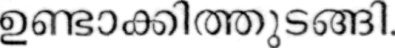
ഉണ്ടാക്കിത്തുടങ്ങി.
